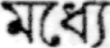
মধ্যে
